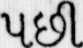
પછી
